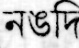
নঙদি
